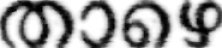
താഴെ
